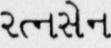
રત્નસેન
